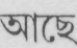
আছে
